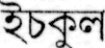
ইচকুল
